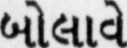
બોલાવે
